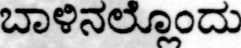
ಬಾಳಿನಲ್ಲೊಂದು
